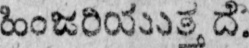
ಹಿಂಜರಿಯುತ್ತದೆ.
